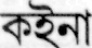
কইনা
